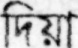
দিয়া
